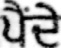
ਪੈਂਦੇ
